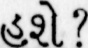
હશે?
